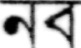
নব
